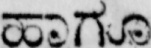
ಹಾಗೂ
